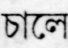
চালে
